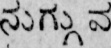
ನುಗ್ಗುವ
